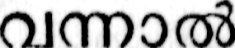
വന്നാല്‍
